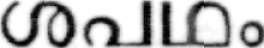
ശപഥം
